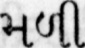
મળી
